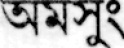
অমসুং
